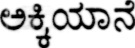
ಅಕ್ಕಿಯಾನೆ
